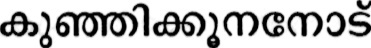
കുഞ്ഞിക്കൂനനോട്
